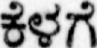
ಕೆಳಗೆ
